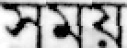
সময়
